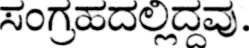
ಸಂಗ್ರಹದಲ್ಲಿದ್ದವು.
